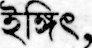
ইঙ্গিৎ,
